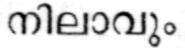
നിലാവും
